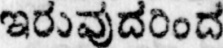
ಇರುವುದರಿಂದ
